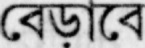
বেড়াবে
